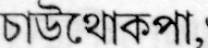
চাউথোকপা,
